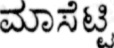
ಮಾಸೆಟ್ಟಿ
